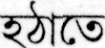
হঠাতে
